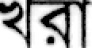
খরা
